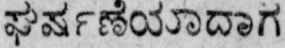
ಘರ್ಷಣೆಯಾದಾಗ
